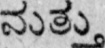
ಮತ್ತು
